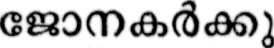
ജോനകര്‍ക്കു
